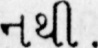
નથી.
